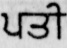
ਪਤੀ
